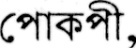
পোকপী,
